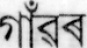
গাঁৱৰ
